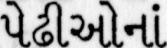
પેઢીઓનાં
